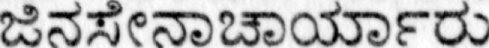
ಜಿನಸೇನಾಚಾರ್ಯಾರು
